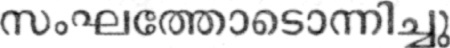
സംഘത്തോടൊന്നിച്ചു
